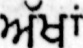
ਅੱਖਾਂ
